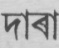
দাৰা
